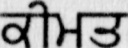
ਕੀਮਤ
